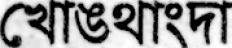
খোঙথাংদা
